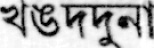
খঙদদুনা
